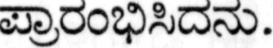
ಪ್ರಾರಂಭಿಸಿದನು.
